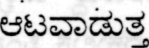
ಆಟವಾಡುತ್ತ
